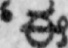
‘ಈ
